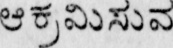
ಆಕ್ರಮಿಸುವ
